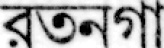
রতনগা
